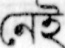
নেই
